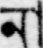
না
